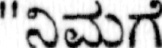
“ನಿಮಗೆ
